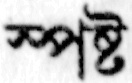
স্পষ্ট
